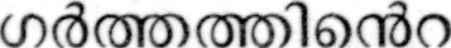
ഗര്‍ത്തത്തിന്റെ
